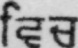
ਵਿਚ
